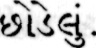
છોડેલું.
